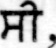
ਸੀ,
